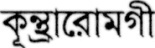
কূন্থ্রারোমগী
